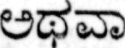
ಅಥವಾ
